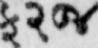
ફરજ
